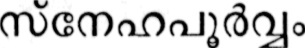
സ്നേഹപൂര്‍വ്വം
